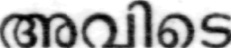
അവിടെ
